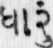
ધારું
